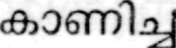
കാണിച്ച
